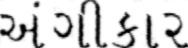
અંગીકાર
